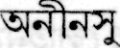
অনীনসু
